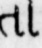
તો
